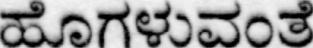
ಹೊಗಳುವಂತೆ
